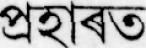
প্রহাৰত
